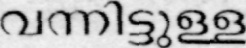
വന്നിട്ടുള്ള
